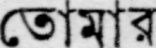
তোমার
